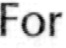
For
